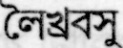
লৈখ্রবসু
